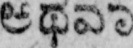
ಅಥವಾ
